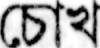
চোখ
